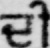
ਦੀ
